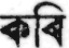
কৰি
